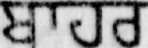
ਬਾਹਰ
